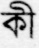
কী
